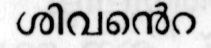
ശിവന്റെ
